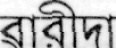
ৱারীদা
